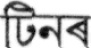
টিনৰ
